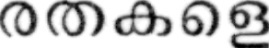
രതകളെ
